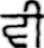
ਵੀ
